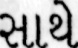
સાથે
